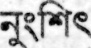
নুংশিৎ
